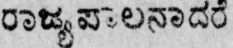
ರಾಜ್ಯಪಾಲನಾದರೆ
